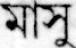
মাসু
